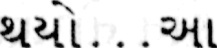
થયો...આ
